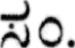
ಸಂ.
